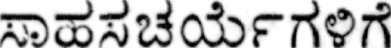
ಸಾಹಸಚರ್ಯೆಗಳಿಗೆ
